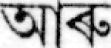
আৰু
